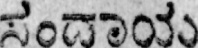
ಸಂದಾಯ
